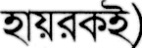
হায়রকই)
